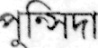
পুন্সিদা
